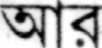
আর
